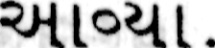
આવ્યા.
